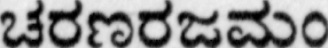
ಚರಣರಜಮಂ
